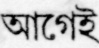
আগেই
